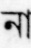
না
